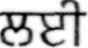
ਲਈ
